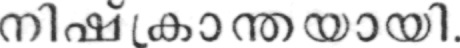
നിഷ്ക്രാന്തയായി.
